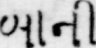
બાની
